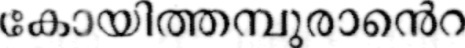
കോയിത്തമ്പുരാന്റെ
